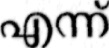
എന്ന്
